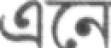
এনে
